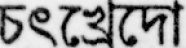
চৎখ্রেদো
